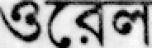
ওরেল
